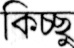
কিচ্ছু
